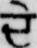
ਦੇ
